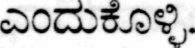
ಎಂದುಕೊಳ್ಳಿ.
